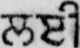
ਲਈ
